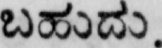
ಬಹುದು.
